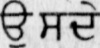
ਉਸਦੇ
